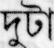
দুটা
